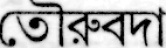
তৌরুবদা
